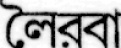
লৈরবা
